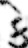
કે
